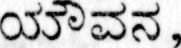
ಯೌವನ,
